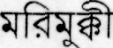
মরিমুক্কী
